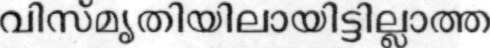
വിസ്മൃതിയിലായിട്ടില്ലാത്ത
